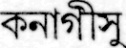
কনাগীসু
